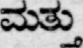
ಮತ್ತು
